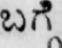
ಬಗ್ಗೆ
